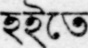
হইতে
